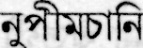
নুপীমচানি
